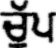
ਚੁੱਪ
